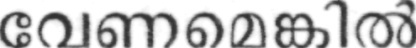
വേണമെങ്കില്‍
